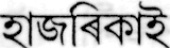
হাজৰিকাই
